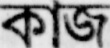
কাজ
